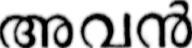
അവന്‍
